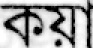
কয়া
